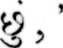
છું,'
